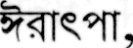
ঈরাৎপা,
